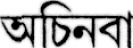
অচিনবা
